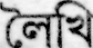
লৈখি
